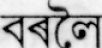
বৰলৈ
